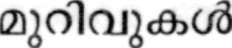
മുറിവുകള്‍
